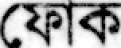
ফোক
